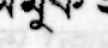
অমুক
